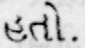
હતો.
